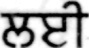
ਲਈ
